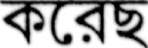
করেছ
